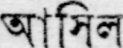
আসিল
